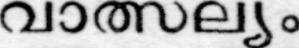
വാത്സല്യം
